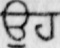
ਉਹ
